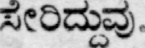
ಸೇರಿದ್ದುವು.
